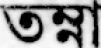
তম্না
